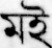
মই
